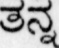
ತನ್ನ
